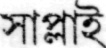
সাপ্লাই
